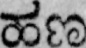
ಹಣ
